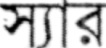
স্যার
